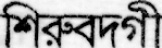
শিরুবদগী
